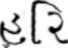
હરિ
